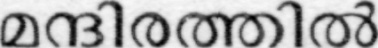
മന്ദിരത്തില്‍
